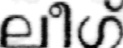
ലീഗ്
